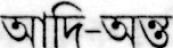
আদি-অন্ত
